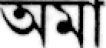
অমা
